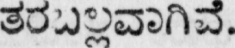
ತರಬಲ್ಲವಾಗಿವೆ.
